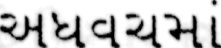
અધવચમાં
